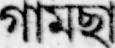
গামছা
